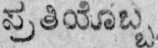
ಪ್ರತಿಯೊಬ್ಬ
